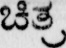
ಚಿತ್ರ
